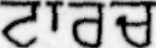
ਟਾਰਚ
